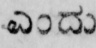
ಎಂದು
